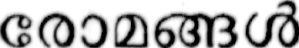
രോമങ്ങള്‍
